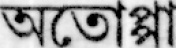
অতোপ্পা
